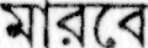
মারবে
